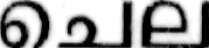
ചെല
